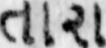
તારા
